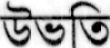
উভতি
